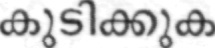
കുടിക്കുക
